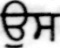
ਉਸ
